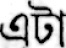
এটা
